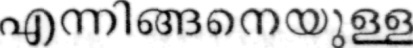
എന്നിങ്ങനെയുള്ള
